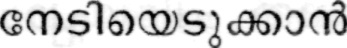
നേടിയെടുക്കാന്‍
